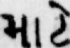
માટે
